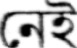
নেই
